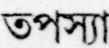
তপস্যা
